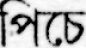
পিচে
